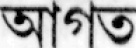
আগত
